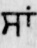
ਸਾਂ
